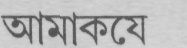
আমাকযে
